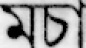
মচা
